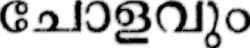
ചോളവും
